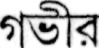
গভীর
